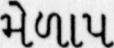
મેળાપ
